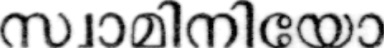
സ്വാമിനിയോ
